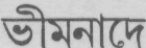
ভীমনাদে
